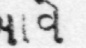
આવે
